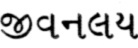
જીવનલય
